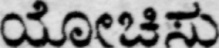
ಯೋಚಿಸು
